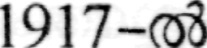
1917-ല്‍
